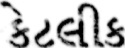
કેટલીક
